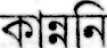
কান্ননি
